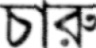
চারু
